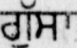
ਗੁੱਸਾ
